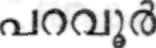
പറവൂര്‍
